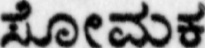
ಸೋಮಕ
